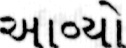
આવ્યો
